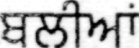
ਬਲੀਆਂ
